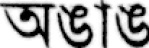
অঙাঙ
